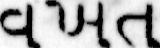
વખત
